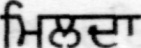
ਮਿਲਦਾ
